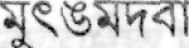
মুৎঙমদবা
